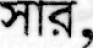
সার,
